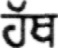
ਹੱਥ
